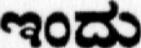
ಇಂದು
